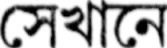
সেখানে
